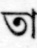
তা
